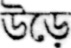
উড়ে
